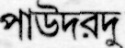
পাউদরদু
